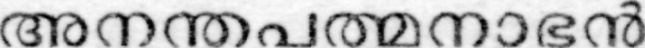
അനന്തപത്മനാഭന്‍
